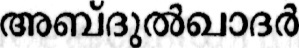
അബ്ദുല്‍ഖാദര്‍
